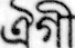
ঐগী
